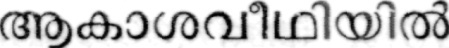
ആകാശവീഥിയില്‍
